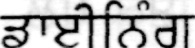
ਡਾਈਨਿੰਗ
